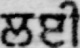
ਲਈ
